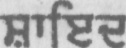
ਸ਼ਾਇਦ
